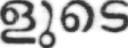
ളുടെ
